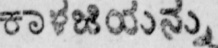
ಕಾಳಜಿಯನ್ನು
